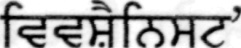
ਵਿਵਸ਼ੈਨਿਸਟ'
